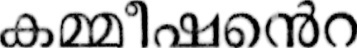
കമ്മീഷന്റെ
